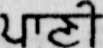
ਪਾਣੀ
